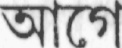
আগে
